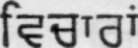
ਵਿਚਾਰਾਂ
